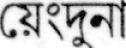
য়েংদুনা
